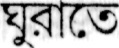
ঘুরাতে
